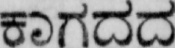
ಕಾಗದದ
